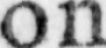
on
